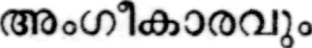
അംഗീകാരവും
